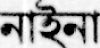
নাইনা
